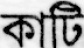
কাটি
